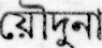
য়ৌদুনা
